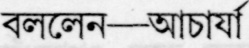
বললেন–আচার্যা
